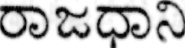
ರಾಜಧಾನಿ
